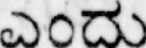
ಎಂದು
